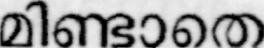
മിണ്ടാതെ
